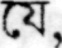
যে,
